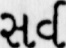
સર્વ
